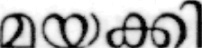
മയക്കി
